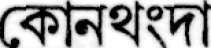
কোনথংদা
